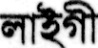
লাইগী
